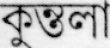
কুন্তলা
